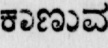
ಕಾಣುವ
